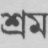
শ্ৰম
